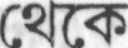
থেকে
